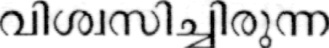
വിശ്വസിച്ചിരുന്ന
